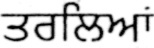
ਤਰਲਿਆਂ
